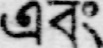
এবং
